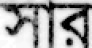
সার
